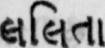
લલિતા
